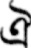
ঐ
